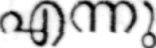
എന്നു
